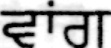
ਵਾਂਗ
